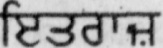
ਇਤਰਾਜ਼
